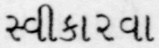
સ્વીકારવા
